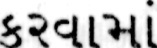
કરવામાં
